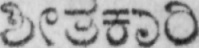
ಶೀತಕಾರಿ
